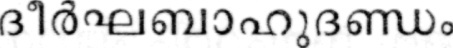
ദീര്‍ഘബാഹുദണ്ഡം
